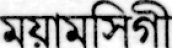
ময়ামসিগী
